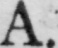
A.
